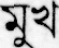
মুখ
